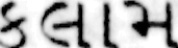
કલામ
